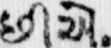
છીએ.
